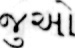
જુઓ
